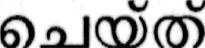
ചെയ്ത്
